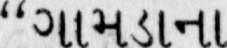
"ગામડાના
